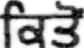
ਕਿਤੋਂ
